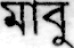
মাবু
